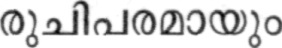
രുചിപരമായും
